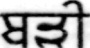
ਬੜੀ
